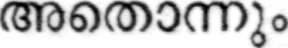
അതൊന്നും
